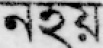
নহয়
